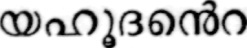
യഹൂദന്റെ
